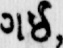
ગઈ,
